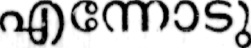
എന്നോടു
